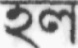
হল
